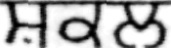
ਸ਼ਕਲ
